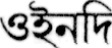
ওইনদি
